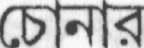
চোনার
